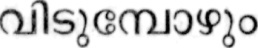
വിടുമ്പോഴും
